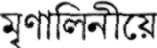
মৃণালিনীয়ে
